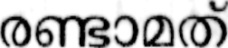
രണ്ടാമത്
